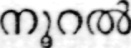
നൂറല്‍
